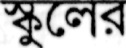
স্কুলের
